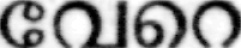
വേറെ
